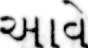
આવે
